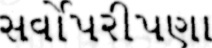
સર્વોપરીપણા
